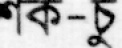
শক-চু
